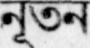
নূতন
